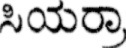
ಸಿಯರ್ರಾ
